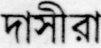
দাসীরা
